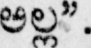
ಅಲ್ಲ”.
